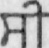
ਸੀ
